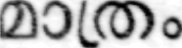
മാത്രം
